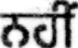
ਨਹੀਂ
